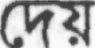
দেয়
